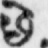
છે.
